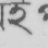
এই
